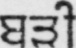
ਬੜੀ
